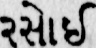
રસોઈ
